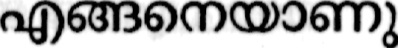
എങ്ങനെയാണു
